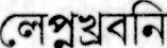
লেপ্নখ্রবনি
